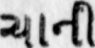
ચાની
